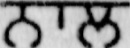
ਨਾਲ
